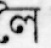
লৈ
